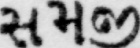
સમજી
